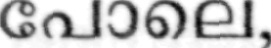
പോലെ,
